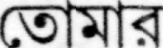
তোমার
